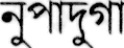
নুপাদুগা
